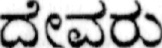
ದೇವರು
